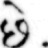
છે.
